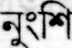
নুংশি
